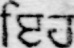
ਇਹ
